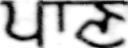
ਪਾਣ
